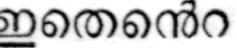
ഇതെന്റെ
